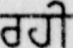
ਰਹੀ
